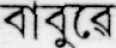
বাবুৱে
